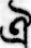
ঐ
